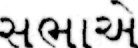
સભાએ
